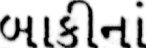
બાકીનાં
